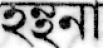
হন্থনা
